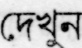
দেখুন
